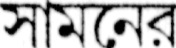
সামনের
